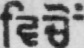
ਵਿਚੋਂ
